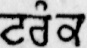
ਟਰੰਕ
